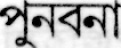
পুনবনা
